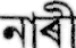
নাৰী
